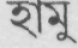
হামু
